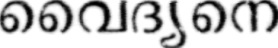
വൈദ്യനെ
